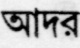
আদর
